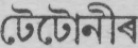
টেটোনীৰ
